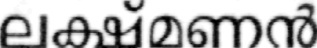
ലക്ഷ്മണന്‍
